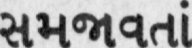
સમજાવતાં
